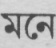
মনে
